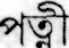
পত্নী
